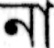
না
